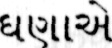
ઘણાએ
